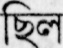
ছিল
